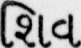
શિવ
